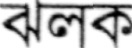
ঝলক
